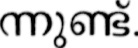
ന്നുണ്ട്.
